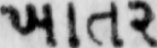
ખાતર
